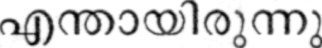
എന്തായിരുന്നു
